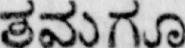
ತಮಗೂ
